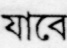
যাবে
